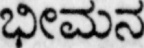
ಭೀಮನ
